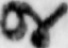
જ
